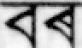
বৰ
